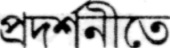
প্রদর্শনীতে
